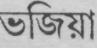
ভজিয়া
